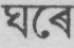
ঘৰে
